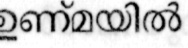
ഉണ്മയില്‍
